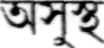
অসুস্থ
